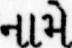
નામે
